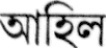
আহিল
